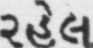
રહેલ
